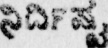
ನಿರ್ದಿಷ್ಟ
